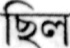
ছিল
